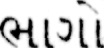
ભાગો
